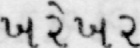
ખરેખર
